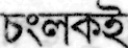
চংলকই
